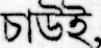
চাউই,
